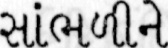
સાંભળીને
